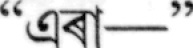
"এৰা-"
